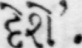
દેશે.
